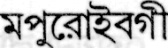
মপুরোইবগী
